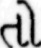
તો
